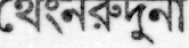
থেংনরুদুনা
